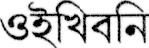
ওইখিবনি
